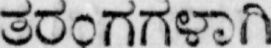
ತರಂಗಗಳಾಗಿ
